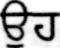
ਉਹ
